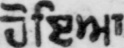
ਹੋਇਆ
